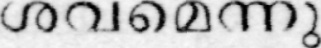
ശവമെന്നു
